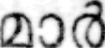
മാര്‍
